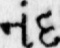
નંદ
